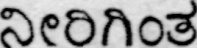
ನೀರಿಗಿಂತ
